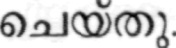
ചെയ്തു.
